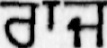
ਰਾਜ
